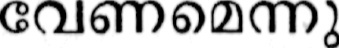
വേണമെന്നു
